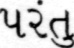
પરંતુ
